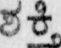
ಶಕ್ತಿ
